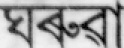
ঘৰুৱা
